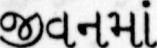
જીવનમાં
